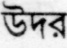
উদর
